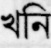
খনি
